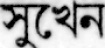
সুখেন
